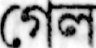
গেল
